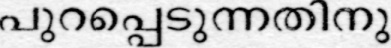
പുറപ്പെടുന്നതിനു
